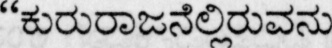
“ಕುರುರಾಜನೆಲ್ಲಿರುವನು
